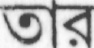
তার
